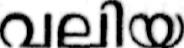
വലിയ
